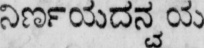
ನಿರ್ಣಯದನ್ವಯ
